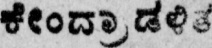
ಕೇಂದ್ರಾಡಳಿತ
